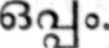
ഒപ്പം.
